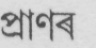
প্রাণৰ
